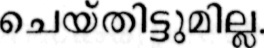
ചെയ്തിട്ടുമില്ല.
